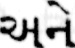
અને
